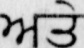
ਅਤੇ
